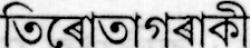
তিৰোতাগৰাকী
